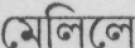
মেলিলে
